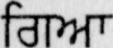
ਗਿਆ
